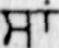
ਸਾਂ
